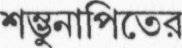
শম্ভুনাপিতের
